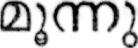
മൂന്നു
